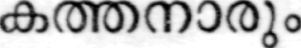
കത്തനാരും
